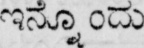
ಇನ್ನೊಂದು
